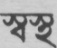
স্বস্থ
